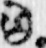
છે.
